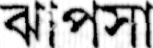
ঝাপসা
